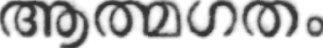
ആത്മഗതം
